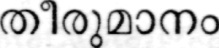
തീരുമാനം
